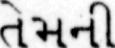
તેમની
